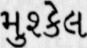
મુશ્કેલ
